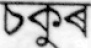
চকুৰ
